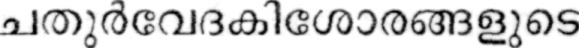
ചതുര്‍വേദകിശോരങ്ങളുടെ
